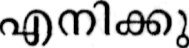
എനിക്കു
